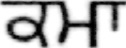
ਕਮਾ
